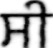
ਸੀ
